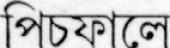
পিচফালে
